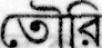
তৌরি
